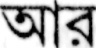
আর
